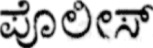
ಪೊಲೀಸ್
